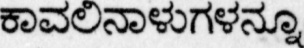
ಕಾವಲಿನಾಳುಗಳನ್ನೂ
